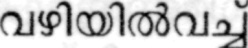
വഴിയില്‍വച്ച്
